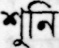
শুনি
